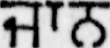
ਜਾਨ
